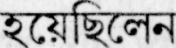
হয়েছিলেন
